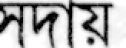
সদায়
